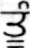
ਤੂੰ
